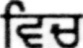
ਵਿਚ
